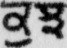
ਕੁਝ
